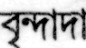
বৃন্দাদা
